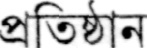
প্রতিষ্ঠান
